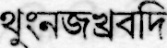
থুংনজখ্রবদি
